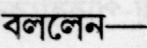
বললেন–
